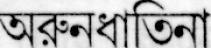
অরুনধাতিনা
